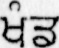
ਖੰਡ
